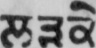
ਲੜਕੇ
